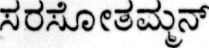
ಸರಸೋತಮ್ಮನ್
